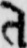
તે
